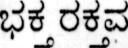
ಭಕ್ತರಕ್ತವ
